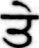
ਤੇ
